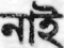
নাই
